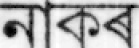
নাকৰ
